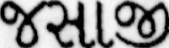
જસાજી
